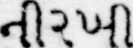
નીરખી
